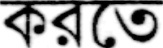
করতে
